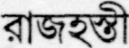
রাজহস্তী
